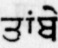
ਤਾਂਬੇ
